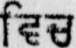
ਵਿਚ
